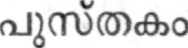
പുസ്തകം
